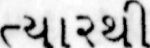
ત્યારથી
